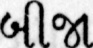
બીજાં
